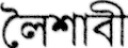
লৈশাবী
